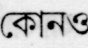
কোনও
